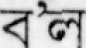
ব'ল
